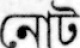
নোট
